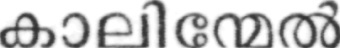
കാലിന്മേല്‍
